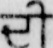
ਦੀ
